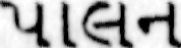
પાલન
